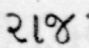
રાજ
